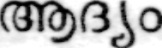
ആദ്യം
